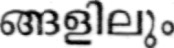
ങ്ങളിലും
